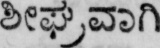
ಶೀಘ್ರವಾಗಿ
